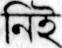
নিই
